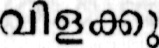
വിളക്കു
